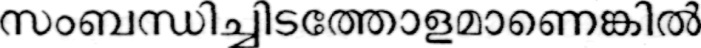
സംബന്ധിച്ചിടത്തോളമാണെങ്കില്‍
